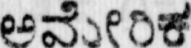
ಅಮೇರಿಕ
